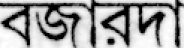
বজারদা
